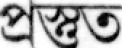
প্রস্তুত
